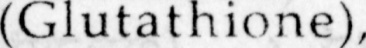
(Glutathione)
